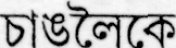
চাঙলৈকে
